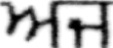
ਅਜ
